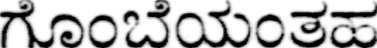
ಗೊಂಬೆಯಂತಹ
